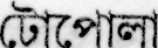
টোপোলা
